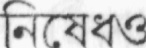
নিষেধও
